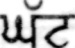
ਘੱਟ
